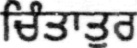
ਚਿੰਤਾਤੁਰ
